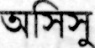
অসিসু
